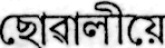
ছোৱালীয়ে
